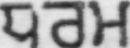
ਧਰਮ
